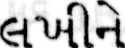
લખીને
